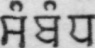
ਸੰਬੰਧ
